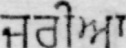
ਜਰੀਆ
